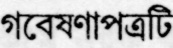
গবেষণাপত্রটি
